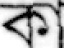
কা
